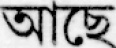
আছে
